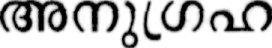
അനുഗ്രഹ
